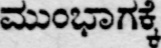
ಮುಂಭಾಗಕ್ಕೆ
